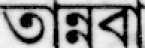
তান্নবা
